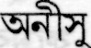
অনীসু
